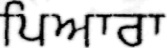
ਪਿਆਰਾ
